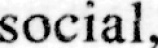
social,
